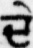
ਦੇ
